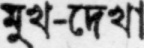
মুখ-দেখা
